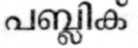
പബ്ലിക്
